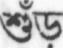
শুঁড়
